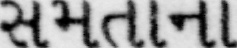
સમતાના
